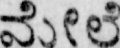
ಮೇಲೆ
